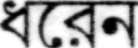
ধরেন
